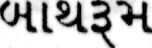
બાથરૂમ
